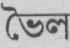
ভৈল
